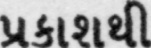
પ્રકાશથી
